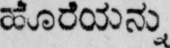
ಹೊರೆಯನ್ನು
